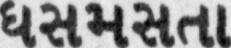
ધસમસતા
